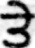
ਤੇ
